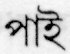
পাই
